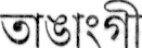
তাঙাংগী
